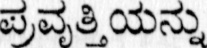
ಪ್ರವೃತ್ತಿಯನ್ನು
